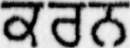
ਕਰਨ
